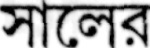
সালের
